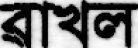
ৱাখল
